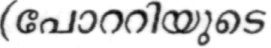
(പോററിയുടെ
